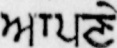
ਆਪਣੇ
